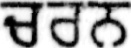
ਚਰਨ
